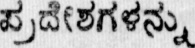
ಪ್ರದೇಶಗಳನ್ನು
